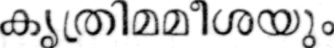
കൃത്രിമമീശയും
